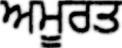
ਅਮੂਰਤ
